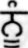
ਨੂੰ
